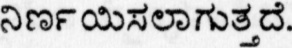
ನಿರ್ಣಯಿಸಲಾಗುತ್ತದೆ.
